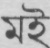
মই
